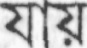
যায়
